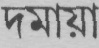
দমায়া
